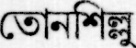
তোনশিল্লু
